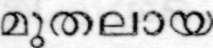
മുതലായ
